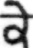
ਕੇ
